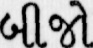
બીજે
